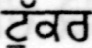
ਟੁੱਕਰ
